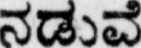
ನಡುವೆ
